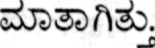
ಮಾತಾಗಿತ್ತು.
